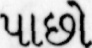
પાછો
